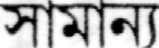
সামান্য
